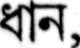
ধান,
